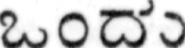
ಒಂದು
